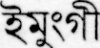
ইমুংগী
